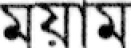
ময়াম
